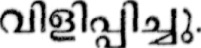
വിളിപ്പിച്ചു.
